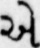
એ
